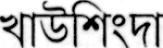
খাউশিংদা
